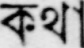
কথা
